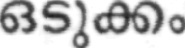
ഒടുക്കം
